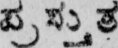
ಪ್ರಸ್ತುತ
